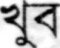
খুব
